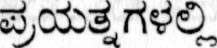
ಪ್ರಯತ್ನಗಳಲ್ಲಿ
